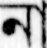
না
